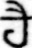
ਹੈ
